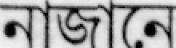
নাজানে
